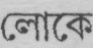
লোকে
